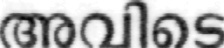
അവിടെ
